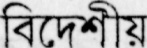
বিদেশীয়
